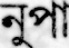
নুপা
